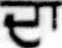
ਦਾ
